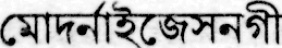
মোদর্নাইজেসনগী
